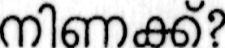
നിണക്ക്?
